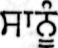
ਸਾਨੂੰ
